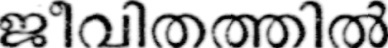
ജീവിതത്തില്‍
